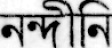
নন্দীনি
